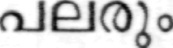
പലരും
